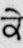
ਕੇ
